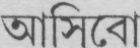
আসিবো
